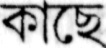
কাছে
